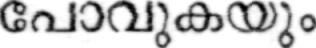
പോവുകയും
